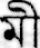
মী
